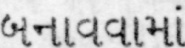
બનાવવામાં
